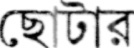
ছোটার
